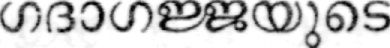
ഗദാഗജ്ജയുടെ
